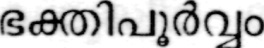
ഭക്തിപൂര്‍വ്വം
